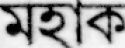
মহাক
